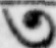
ত
